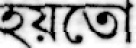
হয়তো
